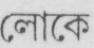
লোকে
